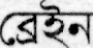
ব্রেইন
